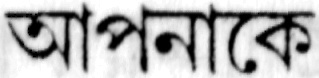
আপনাকে
